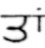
ਤਾਂ
